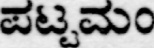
ಪಟ್ಟಮ೦
